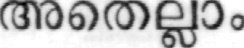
അതെല്ലാം
